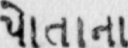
પોતાના
